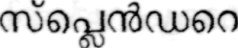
സ്പ്ലെന്‍ഡറെ
